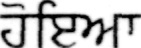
ਹੋਇਆ
